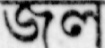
জল
